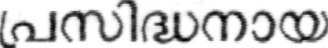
പ്രസിദ്ധനായ
